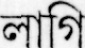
লাগি
